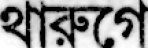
থারুগে
